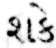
શકે
